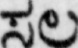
ಸಲ
